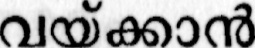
വയ്ക്കാന്‍
